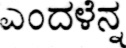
ಎಂದಳೆನ್ನ
